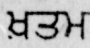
ਖ਼ਤਮ
